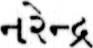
નરેન્દ્ર
